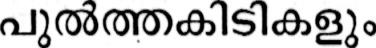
പുല്‍ത്തകിടികളും
